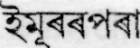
ইমূৰৰপৰা
